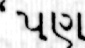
'પણ
